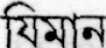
যিমান
